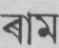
ৰাম
